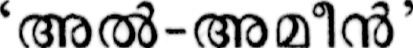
‘അല്‍-അമീന്‍’
